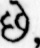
છે,
